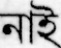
নাই
